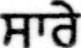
ਸਾਰੇ
